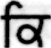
ਕਿ
